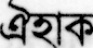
ঐহাক
